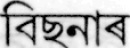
বিছনাৰ
